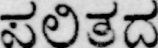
ಪಲಿತದ
